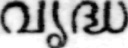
വൃദ്ധ
